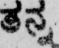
ತನ್ನ
